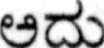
ಅದು
